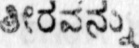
ತೀರವನ್ನು
